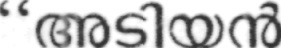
"അടിയന്‍
